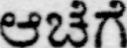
ಆಚೆಗೆ
